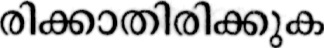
രിക്കാതിരിക്കുക
